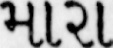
મારા
